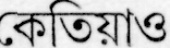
কেতিয়াও
